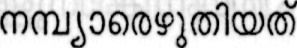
നമ്പ്യാരെഴുതിയത്
